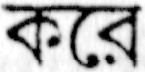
করে
